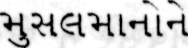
મુસલમાનોને
